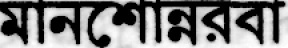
মানশোন্নরবা
